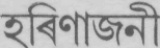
হৰিণাজনী
